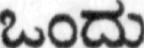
ಒಂದು
